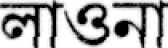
লাওনা
